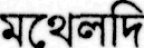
মথেলদি
